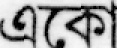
একো
